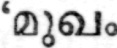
‘മുഖം
